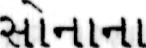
સોનાના
